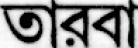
তারবা
